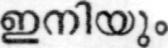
ഇനിയും
